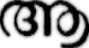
ആ
